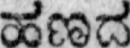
ಹಣದ
